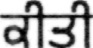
ਕੀਤੀ
